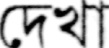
দেখা
